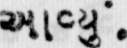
આવ્યું.
